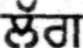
ਲੱਗ
